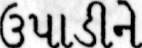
ઉપાડીને
